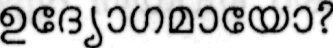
ഉദ്യോഗമായോ?
